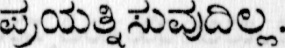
ಪ್ರಯತ್ನಿಸುವುದಿಲ್ಲ.
